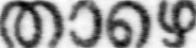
താഴെ
